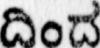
ದಿಂದ
